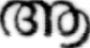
ആ
